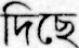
দিছে
